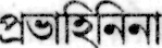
প্রভাহিনি
